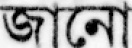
জানো
